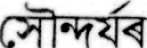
সৌন্দর্যৰ
